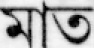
মাত
